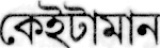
কেইটামান
